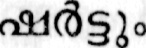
ഷര്‍ട്ടും
